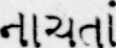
નાચતાં
